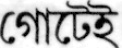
গোটেই
